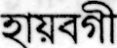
হায়বগী
